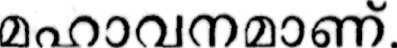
മഹാവനമാണ്.
